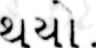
થયો.
